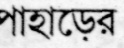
পাহাড়ের
